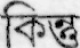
কিন্তু
